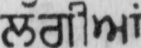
ਲੱਗੀਆਂ
